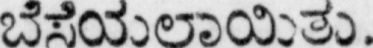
ಬೆಸೆಯಲಾಯಿತು.
